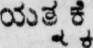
ಯತ್ನಕ್ಕೆ
